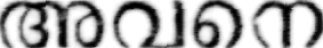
അവനെ
